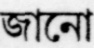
জানো
